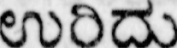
ಉರಿದು
